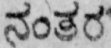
ನಂತರ
